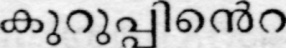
കുറുപ്പിന്റെ
